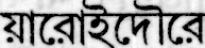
য়ারোইদৌরে
